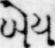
બેય
